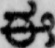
ಈ
